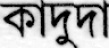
কাদুদা
